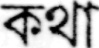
কথা
